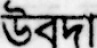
উবদা
